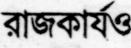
রাজকার্যও
